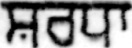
ਸ਼ਰਧਾ
